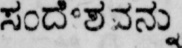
ಸಂದೇಶವನ್ನು
